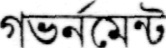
গভর্নমেন্ট
